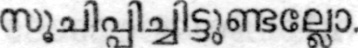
സൂചിപ്പിച്ചിട്ടുണ്ടല്ലോ.
